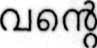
വന്റെ
